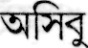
অসিবু
